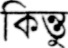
কিন্তু
